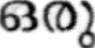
ഒരു
